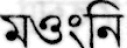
মওংনি
